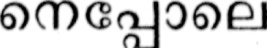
നെപ്പോലെ
